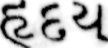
હ્રદય
